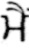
ਮੈਂ
